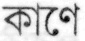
কাণে
